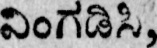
ವಿಂಗಡಿಸಿ,
